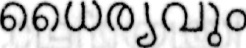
ധൈര്യവും
